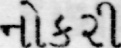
નોકરી
